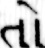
તો
